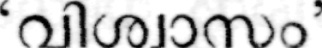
‘വിശ്വാസം'
